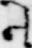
ને
